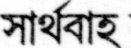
সার্থবাহ
